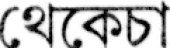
থেকেচা
